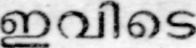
ഇവിടെ
